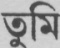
তুমি
